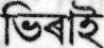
ভিৰাই
